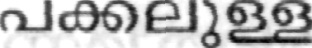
പക്കലുള്ള
